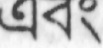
এবং
